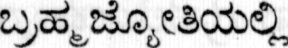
ಬ್ರಹ್ಮಜ್ಯೋತಿಯಲ್ಲಿ
